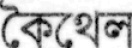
কৈথেল
